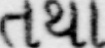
તથા
